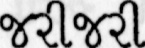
જરીજરી
